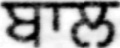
ਬਾਲ
